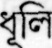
ধূলি
